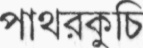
পাথরকুচি
